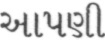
આપણી
